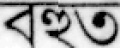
বহুত
